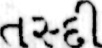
તસ્દી
